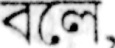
বলে,
